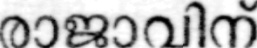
രാജാവിന്
